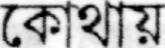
কোথায়
